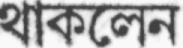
থাকলেন
